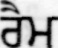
ਰੈਮ
